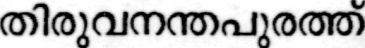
തിരുവനന്തപുരത്ത്
